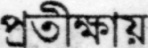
প্রতীক্ষায়
